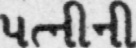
પત્નીની
